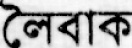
লৈবাক
